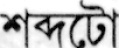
শব্দটো
